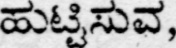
ಹುಟ್ಟಿಸುವ,
